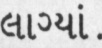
લાગ્યાં.
